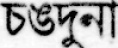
চঙদুনা
